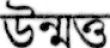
উন্মত্ত
